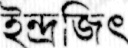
ইন্দ্রজিৎ
